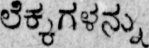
ಲೆಕ್ಕಗಳನ್ನು
